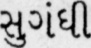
સુગંધી
